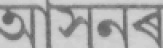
আসনৰ
